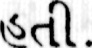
હતી.
